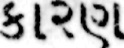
કારણ
